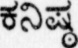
ಕನಿಷ್ಠ
